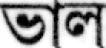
ভাল
